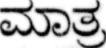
ಮಾತ್ರ
